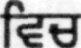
ਵਿਚ
